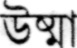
উষ্মা
